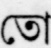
তো
